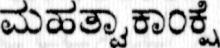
ಮಹತ್ವಾಕಾಂಕ್ಷೆ
